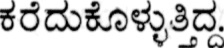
ಕರೆದುಕೊಳ್ಳುತ್ತಿದ್ದ.
